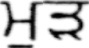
ਮੁੜ
